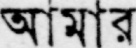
আমার
